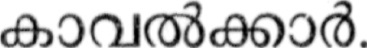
കാവല്‍ക്കാര്‍.
